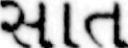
સાત
